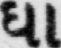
ઘા
